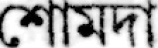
শোমদা
